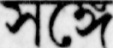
সঙ্গে
